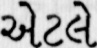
એટલે
